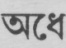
অধে
